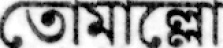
তোমাল্লো
